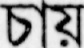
চায়
